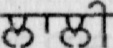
ਲਾਲੀ
